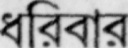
ধরিবার
